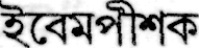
ইবেমপীশক
